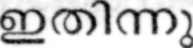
ഇതിന്നു
